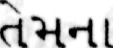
તેમના
